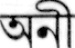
অনী
